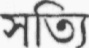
সত্যি
